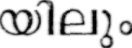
യിലും
